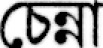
চেন্না
